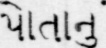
પોતાનું
